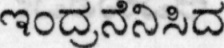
ಇಂದ್ರನೆನಿಸಿದ
